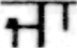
ਜਾ
